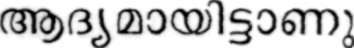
ആദ്യമായിട്ടാണു
